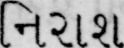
નિરાશ
